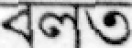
বলত
